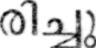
രിച്ചു
